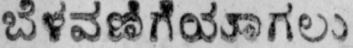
ಬೆಳವಣಿಗೆಯಾಗಲು
